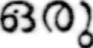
ഒരു
